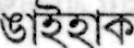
ঙাইহাক
